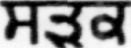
ਸੜਕ
